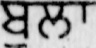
ਬੁਲਾ
